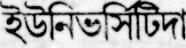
ইউনিভর্সিটিদা
